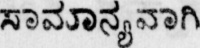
ಸಾಮಾನ್ಯವಾಗಿ
